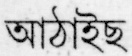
আঠাইছ
